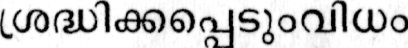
ശ്രദ്ധിക്കപ്പെടുംവിധം
